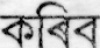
কৰিব
